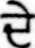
ਦੇ
